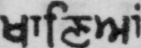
ਖਾਣਿਆਂ
